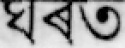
ঘৰত
